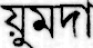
য়ুমদা
